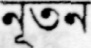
নূতন
